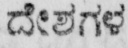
ದೇಶಗಳ
